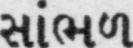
સાંભળ
